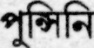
পুন্সিনি
